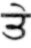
ਤੇ
